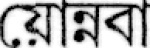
য়োন্নবা
